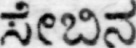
ಸೇಬಿನ
